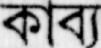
কাব্য
